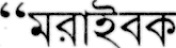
“মরাইবক
